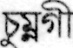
চুম্নগী
